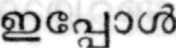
ഇപ്പോള്‍
